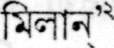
মিলান্’২
